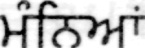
ਮੰਨਿਆ
